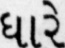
ધારે
